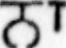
ਨਾ
